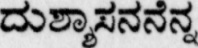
ದುಶ್ಯಾಸನನೆನ್ನ
